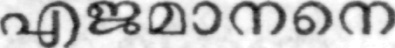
എജമാനനെ
